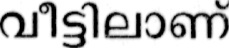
വീട്ടിലാണ്
